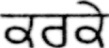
ਕਰਕੇ
